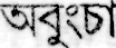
অবুংচা
